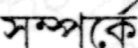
সম্পর্কে
